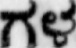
ಗಳ
